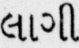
લાગી
